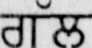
ਗੱਲ
